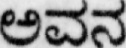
ಅವನ
